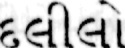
દલીલો
